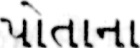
પોતાના
